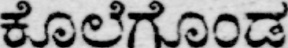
ಕೊಲೆಗೊಂಡ
